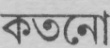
কতনো
